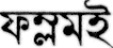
ফম্লমই
